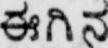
ಈಗಿನ
